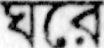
ঘরে
